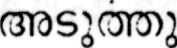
അടുത്തു
